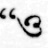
“ও
